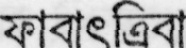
ফাবাৎত্রিবা
